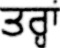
ਤਰ੍ਹਾਂ
